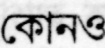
কোনও
